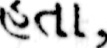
હતા,
